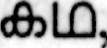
കഥ,
